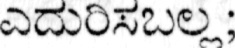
ಎದುರಿಸಬಲ್ಲ;
